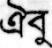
ঐবু
